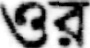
ওর
